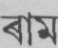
ৰাম
